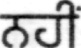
ਨਹੀਂ
